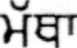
ਮੱਥਾ
